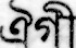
ঐগী
